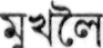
মুখলৈ
